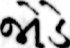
જોડે
